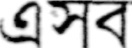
এসব
